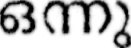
ഒന്നു
